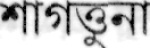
শাগত্তুনা
